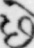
છે
